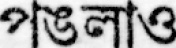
পঙলাও
